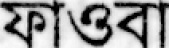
ফাওবা
